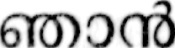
ഞാന്‍
